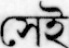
সেই
